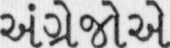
અંગ્રેજોએ
